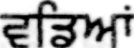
ਵਡਿਆਂ
